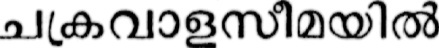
ചക്രവാളസീമയില്‍
